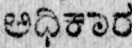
ಅಧಿಕಾರ
